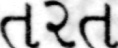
તરત
